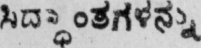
ಸಿದ್ದಾಂತಗಳನ್ನು
